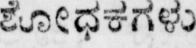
ಶೋಧಕಗಳು
